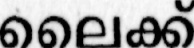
ലൈക്ക്
